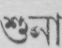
শুনা
